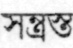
সন্ত্রস্ত
